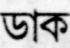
ডাক
